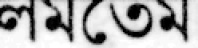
লমতেম
